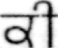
ਕੀ
